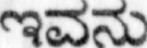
ಇವನು
